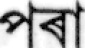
পৰা
